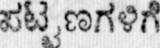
ಪಟ್ಟಣಗಳಿಗೆ
